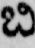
ಬಿ
